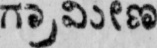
ಗ್ರಾಮೀಣ
